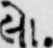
લો.
